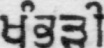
ਖੰਭੜੀ
